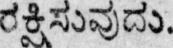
ರಕ್ಷಿಸುವುದು.
